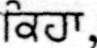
ਕਿਹਾ,
